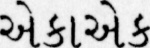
એકાએક
